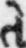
તે
